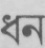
ধন
